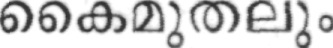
കൈമുതലും
